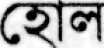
হোল
